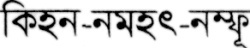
কিহন-নমহৎ-নম্ফূ
